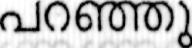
പറഞ്ഞു
